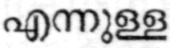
എന്നുള്ള
